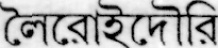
লৈরোইদৌরি
